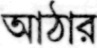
আঠার
